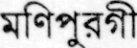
মণিপুরগী
